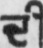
ਦੀ
